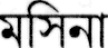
মসিনা
